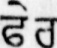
ਫੇਰ
